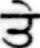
ਤੇ
